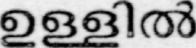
ഉള്ളില്‍
